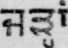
ਜੜ੍ਹਾਂ
